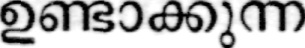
ഉണ്ടാക്കുന്ന
